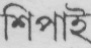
শিপাই
